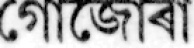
গোজোৰা
